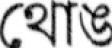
থোঙ
